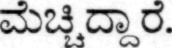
ಮೆಚ್ಚಿದ್ದಾರೆ.
